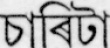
চাৰিটা
